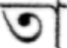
তা
